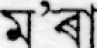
ম'ৰা
